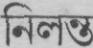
নিলন্ত
